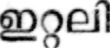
ഇറ്റലി
